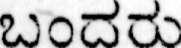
ಬಂದರು
